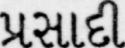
પ્રસાદી
